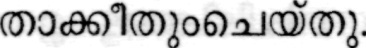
താക്കീതുംചെയ്തു.
